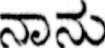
ನಾನು
